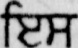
ਇਸ
